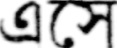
এসে
